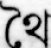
থৈ
